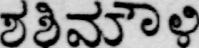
ಶಶಿಮೌಳಿ
